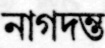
নাগদন্ত
